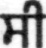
ਸੀ
